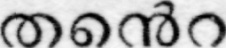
തന്റെ
